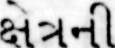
ક્ષેત્રની
